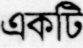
একটি
